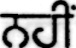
ਨਹੀਂ
